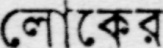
লোকের
